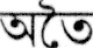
অতৈ
